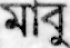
মাবু
